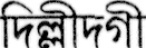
দিল্লীদগী
